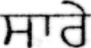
ਸਾਰੇ
